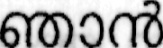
ഞാന്‍
